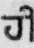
ਹੀ
